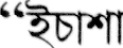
“ইচাশা
